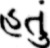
હતું
